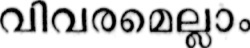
വിവരമെല്ലാം
